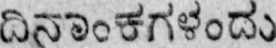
ದಿನಾಂಕಗಳಂದು
